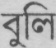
বুলি
